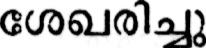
ശേഖരിച്ചു
